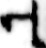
ન
